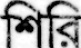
শিরি
